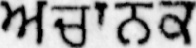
ਅਚਾਨਕ
